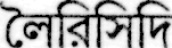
লৈরিসিদি
